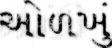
ઓળખું
